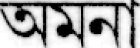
অমনা
